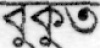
বুকুত
